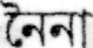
নৈনা
